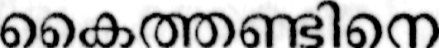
കൈത്തണ്ടിനെ
